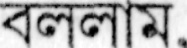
বললাম,
